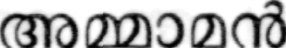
അമ്മാമന്‍
